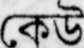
কেউ
